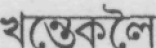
খন্তেকলৈ
